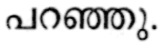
പറഞ്ഞു.
